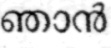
ഞാന്‍
